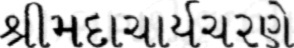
શ્રીમદાચાર્યચરણે
